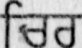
ਚਿਰ
